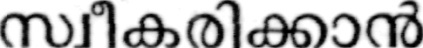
സ്വീകരിക്കാന്‍
